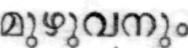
മുഴുവനും
